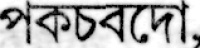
পকচবদো,
